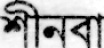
শীনবা
